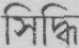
সিদ্ধি
